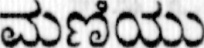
ಮಣಿಯು
